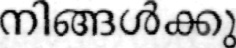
നിങ്ങള്‍ക്കു
